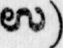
ಉ)
